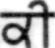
ਕੀ
